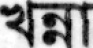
খন্না
